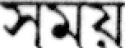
সময়
